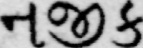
નજીક
